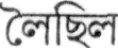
লৈছিল
